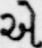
એ
